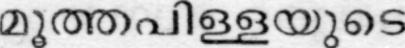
മൂത്തപിള്ളയുടെ
